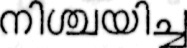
നിശ്ചയിച്ച
